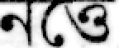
নত্তে
